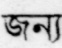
জন্য
